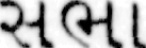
સભા
